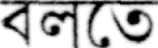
বলতে
